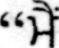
''ਮੈਂ
